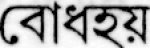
বোধহয়
